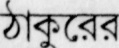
ঠাকুরের
